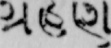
ગ્રહણ
